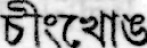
চীংখোঙ
